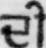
ਦੀ
